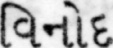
વિનોદ
